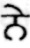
ਨੇ
